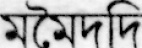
মমৈদদি
